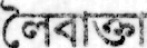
লৈবাক্তা
